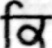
ਕਿ
